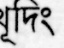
খূদিং
